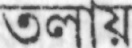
তলায়
